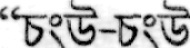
“চংউ-চংউ
